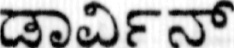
ಡಾರ್ವಿನ್
